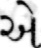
એ
